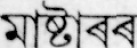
মাষ্টাৰৰ
